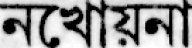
নখোয়না
